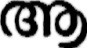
ആ
